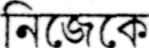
নিজেকে
